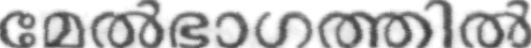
മേല്‍ഭാഗത്തില്‍
